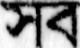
সব
